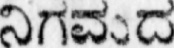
ನಿಗಮದ
